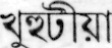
খুহুটীয়া
